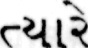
ત્યારે
